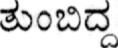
ತುಂಬಿದ್ದ
